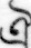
ঐ
